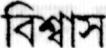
বিশ্বাস
